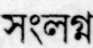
সংলগ্ন
